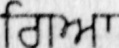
ਗਿਆ
